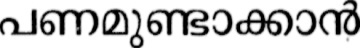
പണമുണ്ടാക്കാന്‍
